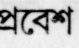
প্রবেশ
